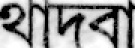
থাদবা
